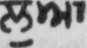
ਲੁਆ
